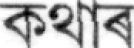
কথাৰ
